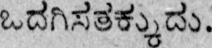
ಒದಗಿಸತಕ್ಕುದು.
